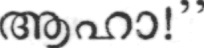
ആഹാ!"
